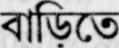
বাড়িতে
